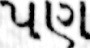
પણ
